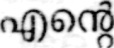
എന്റെ
